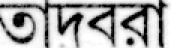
তাদবরা
